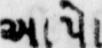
આપો
